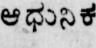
ಆಧುನಿಕ
